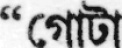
"গোটা
